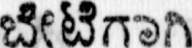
ಬೇಟೆಗಾಗಿ
